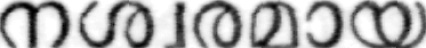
നശ്വരമായ
